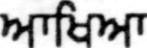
ਆਖਿਆ
